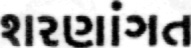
શરણાંગત
